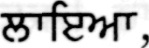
ਲਾਇਆ,
